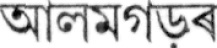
আলমগড়ৰ
